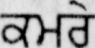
ਕਮਰੇ
